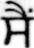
ਸੈਂ
